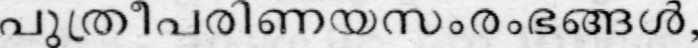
പുത്രീപരിണയസംരഭങ്ങള്‍,
